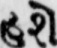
હશે
